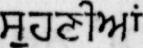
ਸੁਹਣੀਆਂ
